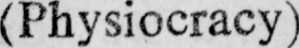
(Physiocracy)
